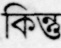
কিন্তু
